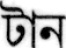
টান
